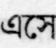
এসে
